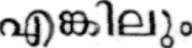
എങ്കിലും
